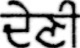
ਦੇਣੀ
